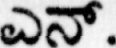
ಎನ್.
